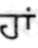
ਹਾਂ
